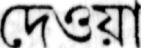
দেওয়া
